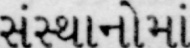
સંસ્થાનોમાં
